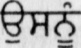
ਉਸਨੂੰ
